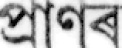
প্রাণৰ
